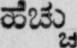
ಹೆಚ್ಚು
